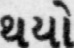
થયો
